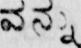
ವನ್ನು
